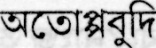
অতোপ্পবুদি
